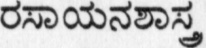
ರಸಾಯನಶಾಸ್ತ್ರ
